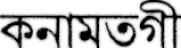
কনামতগী
